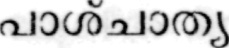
പാശ്ചാത്യ
